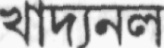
খাদ্যনল
